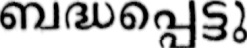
ബദ്ധപ്പെട്ടു
